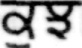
ਕੁਝ
